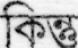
কিন্তু
